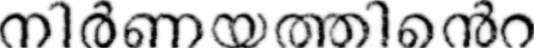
നിര്‍ണയത്തിന്റെ
